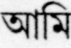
আমি
